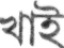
খাই
